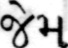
જેમ
